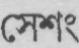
সেশং
